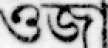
ওজা
